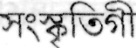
সংস্কৃতিগী
